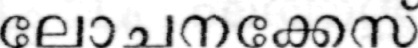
ലോചനക്കേസ്
